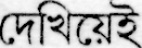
দেখিয়েই
